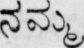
ನಮ್ಮ
